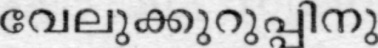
വേലുക്കുറുപ്പിനു
